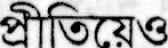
প্রীতিয়েও
